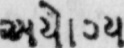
અયોગ્ય
